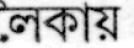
লৈকায়
